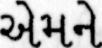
એમને
